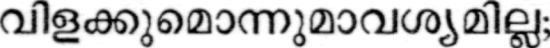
വിളക്കുമൊന്നുമാവശ്യമില്ല;
